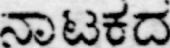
ನಾಟಕದ
